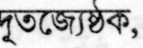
দূতজ্যেষ্ঠক,
